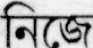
নিজে
